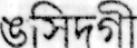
ঙসিদগী
